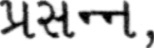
પ્રસન્ન,
